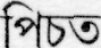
পিচত
